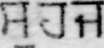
ਸੁਹਜ
